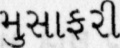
મુસાફરી
